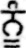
ਨੂੰ
